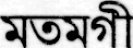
মতমগী
